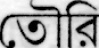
তৌরি
